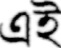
এই
